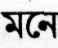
মনে
